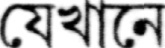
যেখানে
